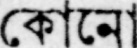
কোনো
